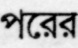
পরের
